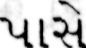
પાસે
